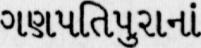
ગણપતિપુરાનાં
